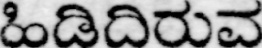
ಹಿಡಿದಿರುವ
